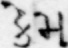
કેમ
